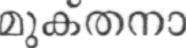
മുക്തനാ
